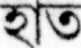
হাত
